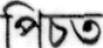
পিচত
